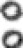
ঃ
